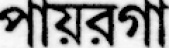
পায়রগা
